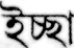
ইচ্ছা
